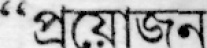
"প্রয়োজন
